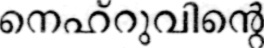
നെഹ്റുവിന്റെ
